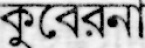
কুবেরনা
